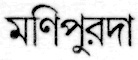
মণিপুরদা
